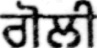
ਗੋਲੀ
